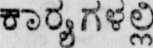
ಕಾರ್‍ಯಗಳಲ್ಲಿ
